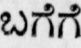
ಬಗೆಗೆ
